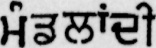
ਮੰਡਲਾਂਦੀ
